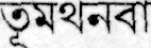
তূমথনবা
